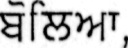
ਬੋਲਿਆ,
